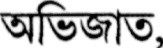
অভিজাত,
